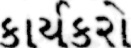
કાર્યકરો
